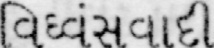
વિધ્વંસવાદી
